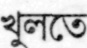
খুলতে
